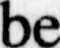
be
